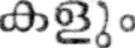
കളും
